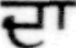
ਦਾ
